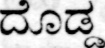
ದೊಡ್ಡ
